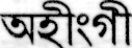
অহীংগী
